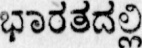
ಭಾರತದಲ್ಲಿ
